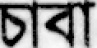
চাবা
